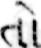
તો
